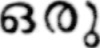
ഒരു
